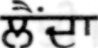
ਲੈਂਦਾ
